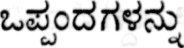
ಒಪ್ಪಂದಗಳನ್ನು
